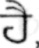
ਹੈ,
